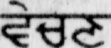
ਵੇਚਣ
